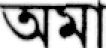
অমা
